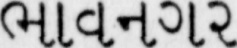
ભાવનગર
